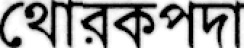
থোরকপদা
